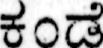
ಕಂಡೆ
